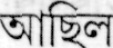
আছিল
